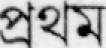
প্রথম
